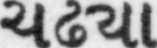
ચઢ્યા
